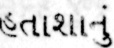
હતાશાનું
